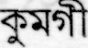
কুমগী
